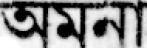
অমনা
